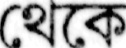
থেকে
